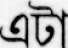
এটা
